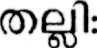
തല്ലി:
